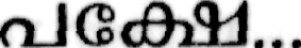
പക്ഷേ...
